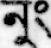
নুং
